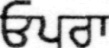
ਓਪਰਾ
